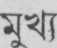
মুখ্য
